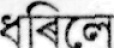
ধৰিলে
